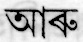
আৰু
